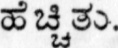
ಹೆಚ್ಚಿತು.
